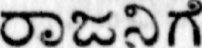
ರಾಜನಿಗೆ
